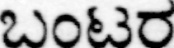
ಬಂಟರ
